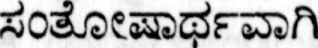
ಸಂತೋಷಾರ್ಥವಾಗಿ
